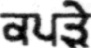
ਕਪੜੇ
